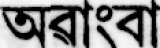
অৱাংবা
